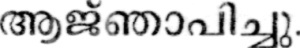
ആജ്ഞാപിച്ചു.
